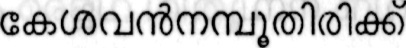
കേശവന്‍നമ്പൂതിരിക്ക്
